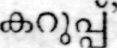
കറുപ്പ്'
